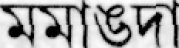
মমাঙদা
